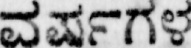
ವರ್ಷಗಳ
